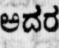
ಅದರ
